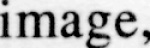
image,
